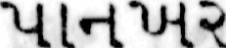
પાનખર
